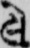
લે
